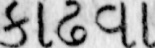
કાઢવા
